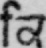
ਕਿ
